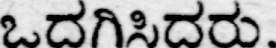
ಒದಗಿಸಿದರು.
